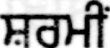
ਸ਼ਰਮੀਂ
